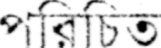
পরিচিত
